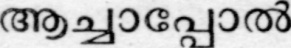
ആച്ചാപ്പോല്‍
